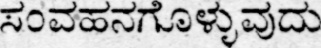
ಸಂವಹನಗೊಳ್ಳುವುದು
